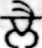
ਲੈ
